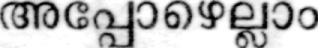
അപ്പോഴെല്ലാം
